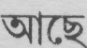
আছে
